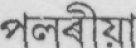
পলৰীয়া
